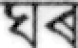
ঘৰ
